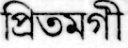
প্রিতমগী
